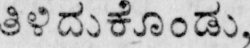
ತಿಳಿದುಕೊಂಡು,
